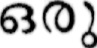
ഒരു
